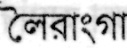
লৈরাংগা
